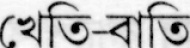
খেতি-বাতি
